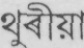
থুৰীয়া
